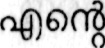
എന്റെ
